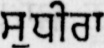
ਸੁਧੀਰਾ
